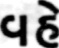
વહે
